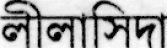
লীলাসিদা
